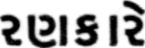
રણકારે
